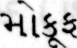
મોકૂફ
